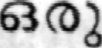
ഒരു
